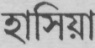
হাসিয়া
